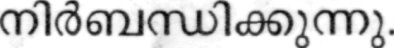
നിര്‍ബന്ധിക്കുന്നു.
